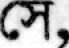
সে,
